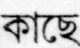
কাছে
